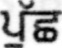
ਪੁੱਛ
